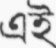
এই
